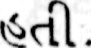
હતી.
